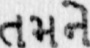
તમને
